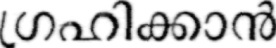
ഗ്രഹിക്കാന്‍
